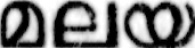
മലയ
